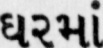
ઘરમાં
